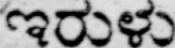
ಇರುಳು
